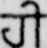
ਹੀ
